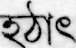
হঠাৎ
